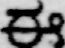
ಈ
